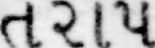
તરાપ
